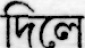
দিলে
